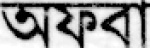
অফবা
